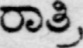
ರಾತ್ರಿ
